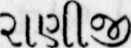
રાણીજી
